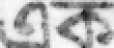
এক
